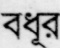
বধূর
